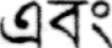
এবং
